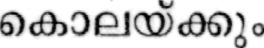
കൊലയ്ക്കും
